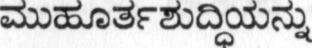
ಮುಹೂರ್ತಶುದ್ಧಿಯನ್ನು
